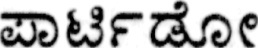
ಪಾರ್ಟಿಡೋ
